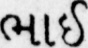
ભાઈ
